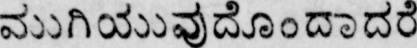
ಮುಗಿಯುವುದೊಂದಾದರೆ
